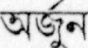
অর্জুন
